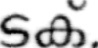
ടക്.
